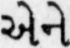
એને
